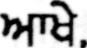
ਆਖੇ,
